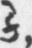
કે,
